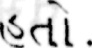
હતો.
